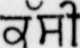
ਕੱਸੀ
